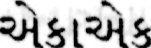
એકાએક
